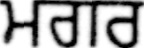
ਮਗਰ
